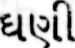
ઘણી
